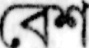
বেশ
